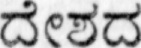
ದೇಶದ
